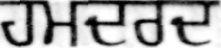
ਹਮਦਰਦ
